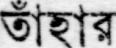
তাঁহার
